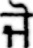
ਜੋ
